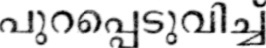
പുറപ്പെടുവിച്ച്
